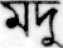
মদু
